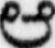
ಆ
